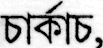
চার্কাচ,
